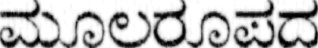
ಮೂಲರೂಪದ
